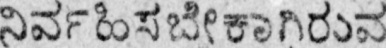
ನಿರ್ವಹಿಸಬೇಕಾಗಿರುವ
